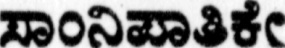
ಸಾಂನಿಪಾತಿಕೇ
